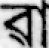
ৱা
